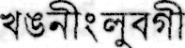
খঙনীংলুবগী
